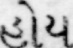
હોય
